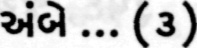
અંબે....(૩)
